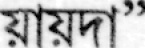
য়ায়দা”
